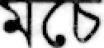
মচে
